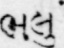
ભલું
